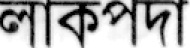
লাকপদা
